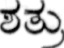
ಶತ್ರು
